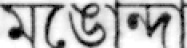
মঙোন্দা
